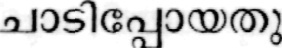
ചാടിപ്പോയതു
